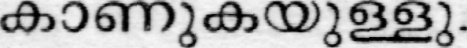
കാണുകയുള്ളു.
